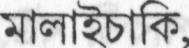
মালাইচাকি,
